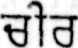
ਚੀਰ
